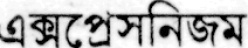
এক্সপ্রেসনিজম
